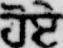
ਹੋਏ
